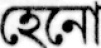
হেনো
